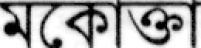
মকোক্তা
